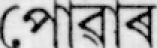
পোৱাৰ
